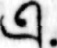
এ.
